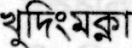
খুদিংমক্না
